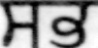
ਸਭ
